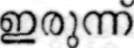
ഇരുന്ന്
